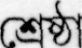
শ্রেষ্ঠা
